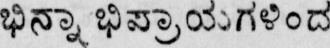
ಭಿನ್ನಾಭಿಪ್ರಾಯಗಳಿಂದ
